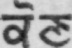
ਕੋਣ
